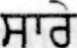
ਸਾਰੇ
